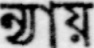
ন্যায়
